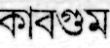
কাবগুম
